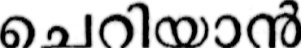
ചെറിയാന്‍
